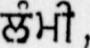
ਲੰਮੀ,
